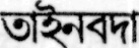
তাইনবদা
